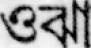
ওঝা
